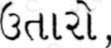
ઉતારો,
